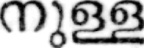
നുള്ള
